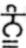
ਨੂੰ
